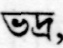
ভদ্র,
